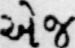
એજ
